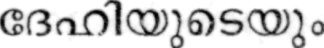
ദേഹിയുടെയും
